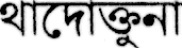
থাদোক্তুনা
